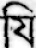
যি
